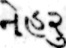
નેહરુ
